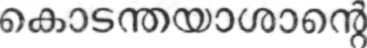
കൊടന്തയാശാന്റെ
